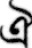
ঐ
